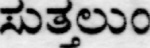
ಸುತ್ತಲುಂ
